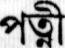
পত্নী
